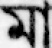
মা
